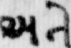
અને
